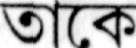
তাকে
